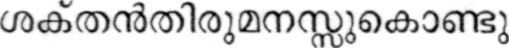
ശക്തന്‍തിരുമനസ്സുകൊണ്ടു
